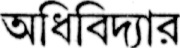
অধিবিদ্যার
